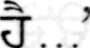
ਹੈ...'
